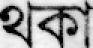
থকা
